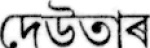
দেউতাৰ
